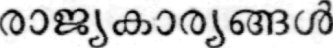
രാജ്യകാര്യങ്ങള്‍
